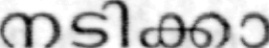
നടിക്കാ
